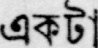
একটা
